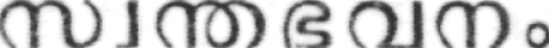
സ്വന്തഭവനം
